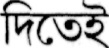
দিতেই
